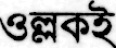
ওল্লকই
